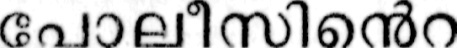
പോലീസിന്റെ
